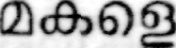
മകളെ
